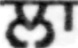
ਲਾ
